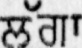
ਲੱਗਾ
